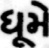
ધૂમે
